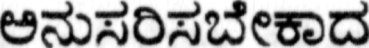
ಅನುಸರಿಸಬೇಕಾದ
